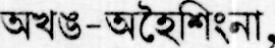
অখঙ-অহৈশিংনা,
